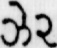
ઝેર
